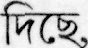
দিছে,
